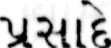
પ્રસાદે
